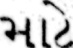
માટે
